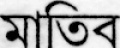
মাতিব
